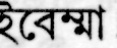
ইবেম্মা
